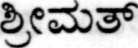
ಶ್ರೀಮತ್
